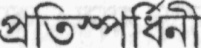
প্রতিস্পর্ধিনী
